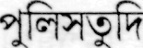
পুলিসতুদি
